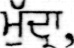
ਮੁੱਦ੍ਰਾ,
